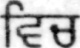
ਵਿਚ
